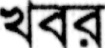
খবর
